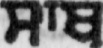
ਸਾਥ
